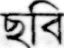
ছবি
